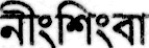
নীংশিংবা
